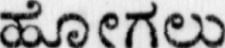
ಹೋಗಲು
